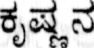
ಕೃಷ್ಣನ
